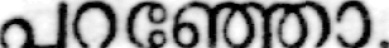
പറഞ്ഞോ.
